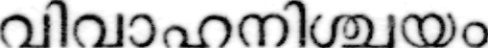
വിവാഹനിശ്ചയം
